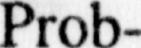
Prob-
